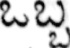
ಒಬ್ಬ
